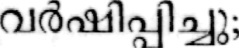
വര്‍ഷിപ്പിച്ചു;
